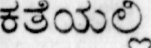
ಕತೆಯಲ್ಲಿ
